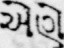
એણે
